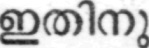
ഇതിനു
